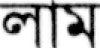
লাম
